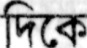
দিকে
